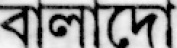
বালাদো
